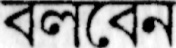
বলবেন
